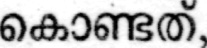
കൊണ്ടത്,
